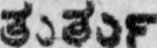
ತುರ್ತು
